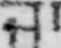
ਜਾ
